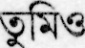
তুমিও
